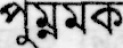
পুম্নমক
